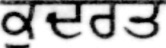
ਕੁਦਰਤ
